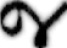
જ
